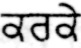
ਕਰਕੇ
